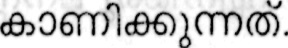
കാണിക്കുന്നത്.
